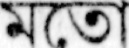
মতো
